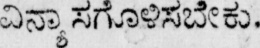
ವಿನ್ಯಾಸಗೊಳಿಸಬೇಕು.
